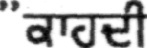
''ਕਾਹਦੀ
